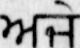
ਅਜੇ
